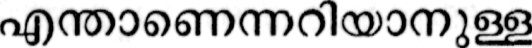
എന്താണെന്നറിയാനുള്ള
